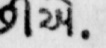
એ
